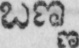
ಬಣ್ಣ
